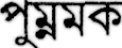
পুম্নমক
